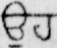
ਉਹ
